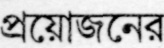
প্রয়োজনের
